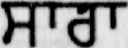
ਸਾਰਾ
